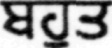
ਬਹੁਤ
